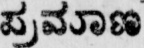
ಪ್ರಮಾಣ
